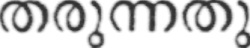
തരുന്നതു
